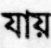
যায়
